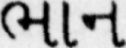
ભાન
